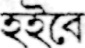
হইবে
